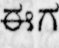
ಈಗ
